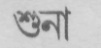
শুনা
